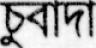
চুবাদা
